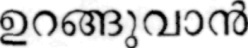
ഉറങ്ങുവാന്‍
